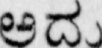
ಅದು
